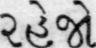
રહેજો
